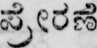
ಪ್ರೇರಣೆ
